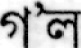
গ'ল
